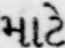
માટે
